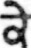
ਕੇ
